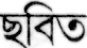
ছবিত
